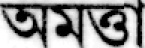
অমত্তা
